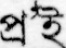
প্র'ই
